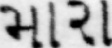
મારા
